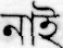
নাই
